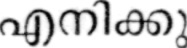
എനിക്കു
